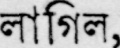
লাগিল,
